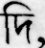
দি,
